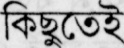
কিছুতেই
